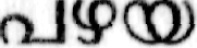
പഴയ
